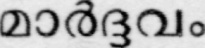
മാര്‍ദ്ദവം
